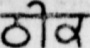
ਠੀਕ
